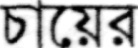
চায়ের
